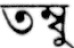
তম্বু
